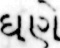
ઘણે
